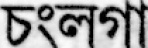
চংলগা
